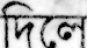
দিলে
